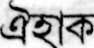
ঐহাক
